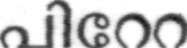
പിറേറ
